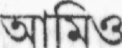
আমিও
